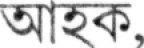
আহক,
